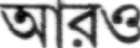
আরও
